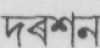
দৰশন
